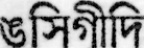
ঙসিগীদি
